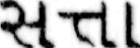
સત્તા
